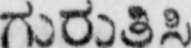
ಗುರುತಿಸಿ
